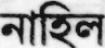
নাহিল
